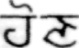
ਹੋਣ
